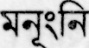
মনূংনি
